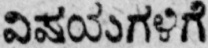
ವಿಷಯಗಳಿಗೆ
